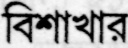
বিশাখার
